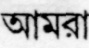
আমরা
